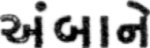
અંબાને
